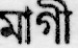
মাগী
